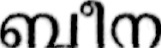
ബീന
